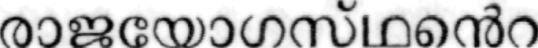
രാജയോഗസ്ഥന്റെ
